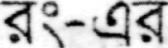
রং-এর
